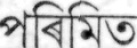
পৰিমিত
